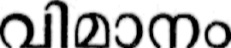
വിമാനം
